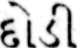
દોડી
